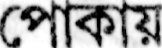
পোকায়
